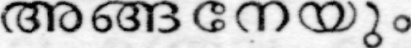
അങ്ങനേയും
